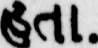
હતા.
